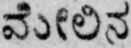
ಮೇಲಿನ
